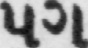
પગ
